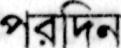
পরদিন
